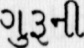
ગુરૂની
